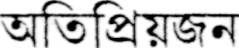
অতিপ্রিয়জন
